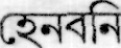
হেনবনি
